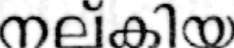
നല്കിയ
